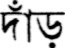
দাঁড়
